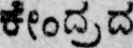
ಕೇಂದ್ರದ
